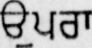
ਉਪਰਾ
